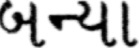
બન્યા
